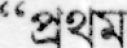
"প্রথম
